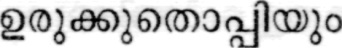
ഉരുക്കുതൊപ്പിയും
